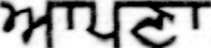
ਆਪਣਾ
